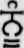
ਨੂੰ
